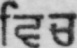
ਵਿਚ
